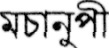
মচানুপী
